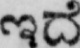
ಇದೆ
